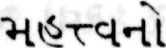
મહત્ત્વનો
